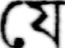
যে
